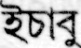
ইচাবু
